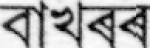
বাখৰৰ
